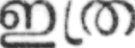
ഇത്ര
